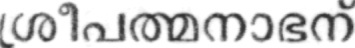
ശ്രീപത്മനാഭന്
